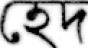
হেদ
